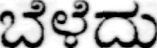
ಬೆಳೆದು
